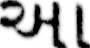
આ
